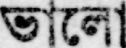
ভালো
